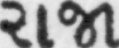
રાજા
